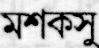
মশকসু
